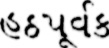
હઠપૂર્વક
